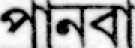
পানবা
